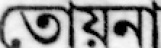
তোয়না
